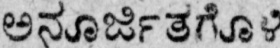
ಅನೂರ್ಜಿತಗೊಳಿ
